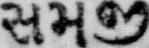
સમજી
